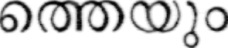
ത്തെയും
